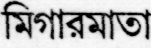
মিগারমাতা
